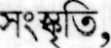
সংস্কৃতি,
